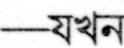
–যখন
